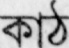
কাঠ
